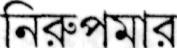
নিরুপমার
